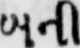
બની
